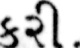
કરી.
